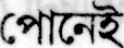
পোনেই
